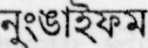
নুংঙাইফম
